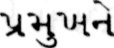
પ્રમુખને
